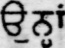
ਉਨ੍ਹਾਂ
